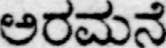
ಅರಮನೆ
